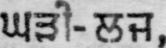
ਘੜੀ-ਲਜ,
